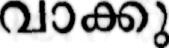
വാക്കു
